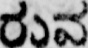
ರುವ
